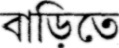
বাড়িতে
